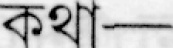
কথা-
